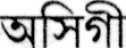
অসিগী
